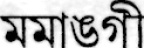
মমাঙগী
